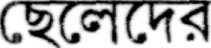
ছেলেদের
